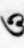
ও
